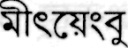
মীৎয়েংবু
